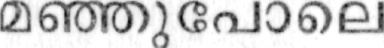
മഞ്ഞുപോലെ
